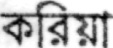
করিয়া
